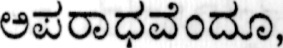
ಅಪರಾಧವೆಂದೂ,
